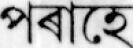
পৰাহে
